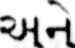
અને
